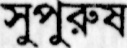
সুপুরুষ
